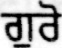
ਗੁਰੋ
